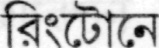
রিংটোনে
